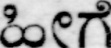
ಹೀಗೆ
